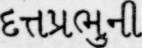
દત્તપ્રભુની
